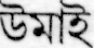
উমাই
